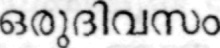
ഒരുദിവസം
